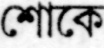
শোকে
